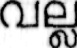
വല്ല
